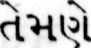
તેમણે
